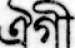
ঐগী
